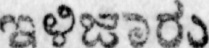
ಇಳಿಜಾರು
